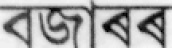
বজাৰৰ
